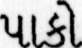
પાકો
